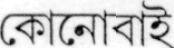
কোনোবাই
